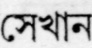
সেখান
